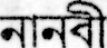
নানবী
